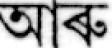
আৰু
